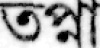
তপ্না
